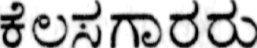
ಕೆಲಸಗಾರರು
